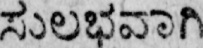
ಸುಲಭವಾಗಿ
